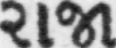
રાજા
